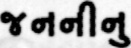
જનનીનુ
